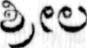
ಶ್ರೀಲ
